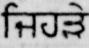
ਜਿਹੜੇ
